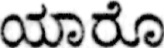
ಯಾರೊ
